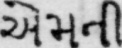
એમની
